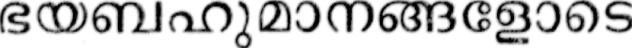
ഭയബഹുമാനങ്ങളോടെ
